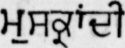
ਮੁਸਕ੍ਰਾਂਦੀ
